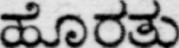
ಹೊರತು
